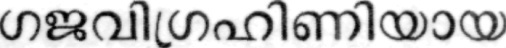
ഗജവിഗ്രഹിണിയായ
